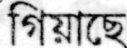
গিয়াছে
